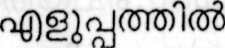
എളുപ്പത്തില്‍
